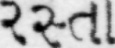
રસ્તા
